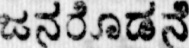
ಜನರೊಡನೆ
